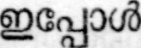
ഇപ്പോള്‍
